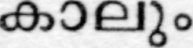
കാലും
